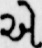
એ
